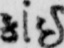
કાંઈ
